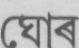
ঘোৰ
